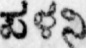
ಪಳನಿ
